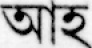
আহ
